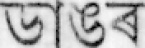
ডাঙৰ
